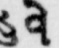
હવે
